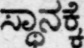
ಸ್ಥಾನಕ್ಕೆ
